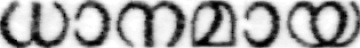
ധാനമായ
